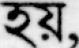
হয়,
